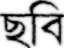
ছবি
